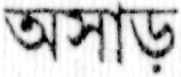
অসাড়
